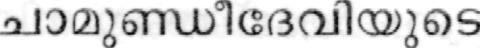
ചാമുണ്ഡീദേവിയുടെ
